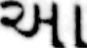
આ
